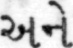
અને
